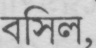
বসিল,
